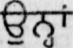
ਉਨ੍ਹਾਂ
